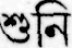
শুনি
